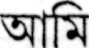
আমি
